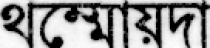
থম্মোয়দা
